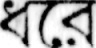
ধরে
